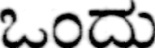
ಒಂದು
